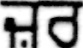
ਜ਼ਰ
